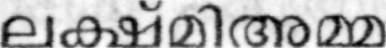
ലക്ഷ്മിഅമ്മ
